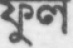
ফুল
